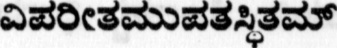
ವಿಪರೀತಮುಪತಸ್ಥಿತಮ್
